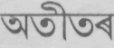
অতীতৰ
